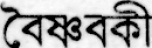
বৈষ্ণবকী
